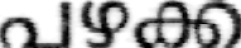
പഴക്ക
